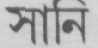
সানি
